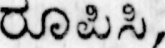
ರೂಪಿಸಿ,
